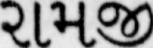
રામજી
